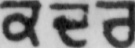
ਕਦਰ
